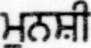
ਮੁਨਸ਼ੀ
